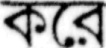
করে
